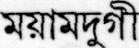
ময়ামদুগী
